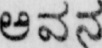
ಅವನ
